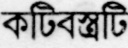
কটিবস্ত্রটি
